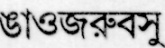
ঙাওজরুবসু
